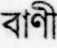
বাণী
